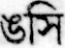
ঙসি
